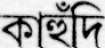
কাহুঁদি
